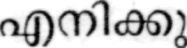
എനിക്കു
